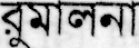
রুমালনা
